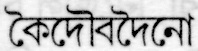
কৈদৌবদৈনো
